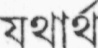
যথার্থ
